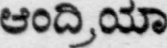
ಆಂದ್ರಿಯಾ
